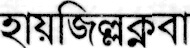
হায়জিল্লক্নবা
